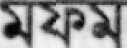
মফম
